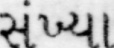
સંખ્યા
